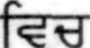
ਵਿਚ
